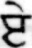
ਏ
